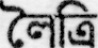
লৈত্রি
